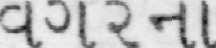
વગરના
